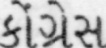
કોંગ્રેસ
